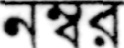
নম্বর
